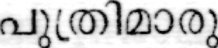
പുത്രിമാരു
